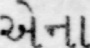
એના
